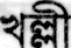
খল্লী
